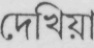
দেখিয়া
